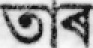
তাৰ
